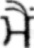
ਮੈਂ
